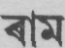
ৰাম
